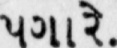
પગારે.
